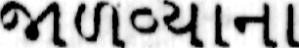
જાળવ્યાના
